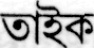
তাইক
